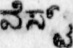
ವೆಸ್ಟ್
